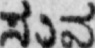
ಸುವ
